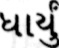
ધાર્યું
